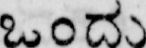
ಒಂದು
